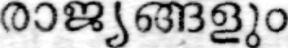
രാജ്യങ്ങളും
